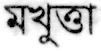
মখুত্তা
